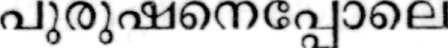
പുരുഷനെപ്പോലെ
